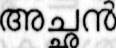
അച്ഛന്‍
